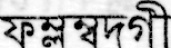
ফম্লম্বদগী
